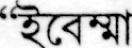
“ইবেম্মা
